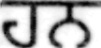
ਹਨ
